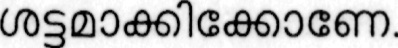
ശട്ടമാക്കിക്കോണേ.
